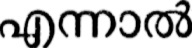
എന്നാല്‍
